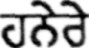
ਹਨੇਰੇ
